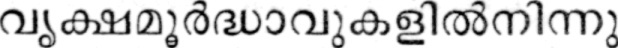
വൃക്ഷമൂര്‍ദ്ധാവുകളില്‍നിന്നു
